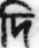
দি
